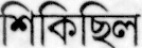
শিকিছিল
